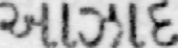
આઝાદ
